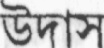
উদাস
